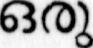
ഒരു
